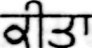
ਕੀਤਾ
